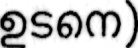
ഉടനെ)
